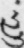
હું
